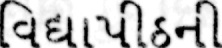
વિદ્યાપીઠની
